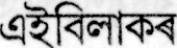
এইবিলাকৰ
